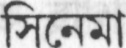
সিনেমা
